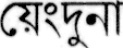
য়েংদুনা
